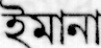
ইমানা
